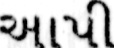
આપી
